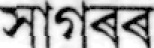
সাগৰৰ
